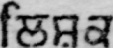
ਲਿਸ਼ਕ
